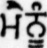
ਮੈਨੂੰ
